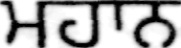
ਮਹਾਨ
